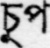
চুপ
